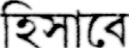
হিসাবে
